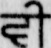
ਵੀ
